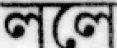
ললে
